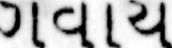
ગવાય
